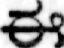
ಈ
